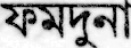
ফমদুনা
